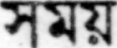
সময়
